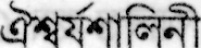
ঐশ্বর্যশালিনী
